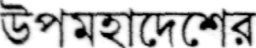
উপমহাদেশের
